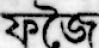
ফজৈ
